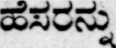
ಹೆಸರನ್ನು
